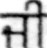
ਜੀ
